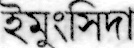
ইমুংসিদা
